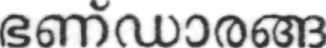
ഭണ്ഡാരങ്ങ
